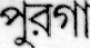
পুরগা
